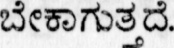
ಬೇಕಾಗುತ್ತದೆ.
